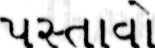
પસ્તાવો
